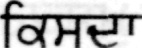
ਕਿਸਦਾ
